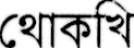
থোকখি
